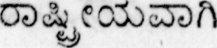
ರಾಷ್ಟ್ರೀಯವಾಗಿ
